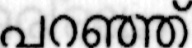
പറഞ്ഞ്
